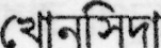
খোনসিদা
